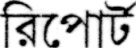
রিপোর্ট
